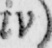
iv)
